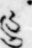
હું
